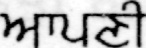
ਆਪਣੀ
